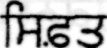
ਸਿਫ਼ਤ
